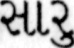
સારુ
